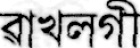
ৱাখলগী
